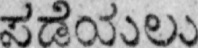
ಪಡೆಯಲು
